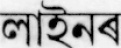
লাইনৰ
